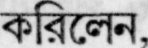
করিলেন,
